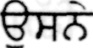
ਉਸਨੇ
